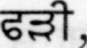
ਫੜੀ,
